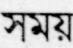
সময়
